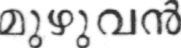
മുഴുവന്‍
